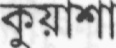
কুয়াশা
